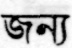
জন্য
